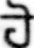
ਹੋ
